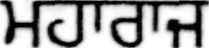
ਮਹਾਰਾਜ
